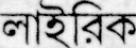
লাইরিক
